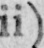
ii)
